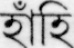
হাঁহি
